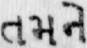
તમને
